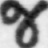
જ
